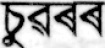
চুৱৰৰ
